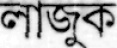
লাজুক
